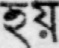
হয়
